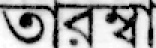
তারম্বা
